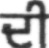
ਦੀ
